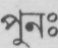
পুনঃ
